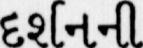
દર્શનની
